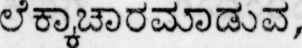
ಲೆಕ್ಕಾಚಾರಮಾಡುವ,
